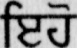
ਇਹੋ
